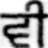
ਵੀ
